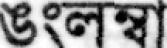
ঙংলম্বা
